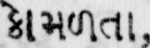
કોમળતા,
